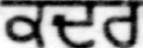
ਕਦਰ
